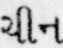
ચીન
